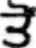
ਤੋਂ
